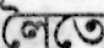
লৈতে
